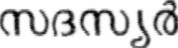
സദസ്യര്‍
